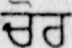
ਚੋਰ
